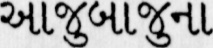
આજુબાજુના
